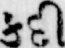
કદી
